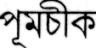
পূমচীক
